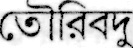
তৌরিবদু
